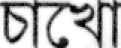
চাখো
